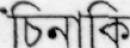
চিনাকি
